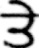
ਤੇ
